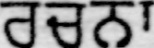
ਰਚਨਾ
